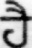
ਹੈ
